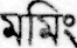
মমিং
